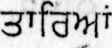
ਤਾਰਿਆਂ
